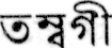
তম্বগী
